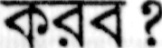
করব?
